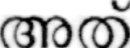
അത്
